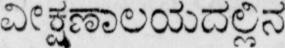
ವೀಕ್ಷಣಾಲಯದಲ್ಲಿನ
